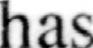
has
